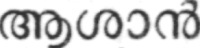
ആശാന്‍
